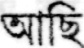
আছি
